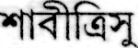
শাবীত্রিসু
